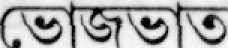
ভোজভাত
